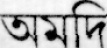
অমদি
